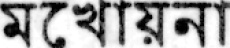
মখোয়না
